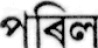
পৰিল
